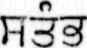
ਸਤੰਭ
